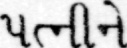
પત્નીને
